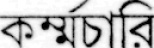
কর্ম্মচারি
